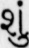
શું
